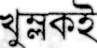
খুম্লকই
